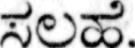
ಸಲಹೆ.
